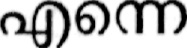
എന്നെ
